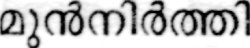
മുന്‍നിര്‍ത്തി
